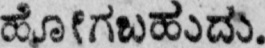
ಹೋಗಬಹುದು.
